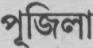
পূজিলা
